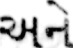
અને
